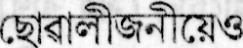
ছোৱালীজনীয়েও
